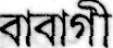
বাবাগী
